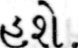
હશે.
